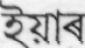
ইয়াৰ
